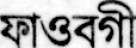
ফাওবগী
